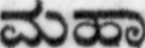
ಮಹಾ
